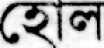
হোল
